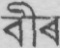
বীৰ
